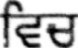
ਵਿਚ
